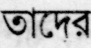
তাদের
